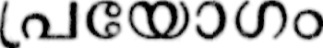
പ്രയോഗം
